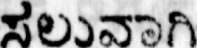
ಸಲುವಾಗಿ
